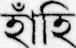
হাঁহি
